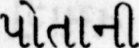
પોતાની
